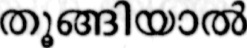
തൂങ്ങിയാല്‍
